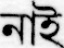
নাই
